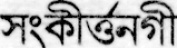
সংকীর্ত্তনগী
